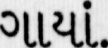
ગાયાં.
